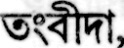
তংবীদা,
